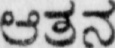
ಆತನ
